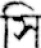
সি
